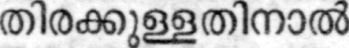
തിരക്കുള്ളതിനാല്‍
